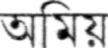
অমিয়
